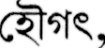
হৌগৎ,
